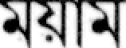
ময়াম
